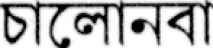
চালোনবা
